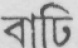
বাঢ়ি
